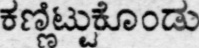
ಕಣ್ಣಿಟ್ಟುಕೊಂಡು
